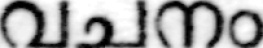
വചനം
